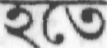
হতে
